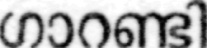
ഗാറണ്ടി
